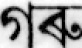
গৰু
